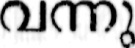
വന്നു
